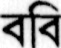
ববি
